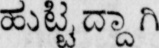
ಹುಟ್ಟಿದ್ದಾಗಿ
